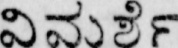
ವಿಮರ್ಶೆ
